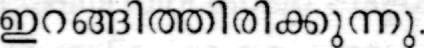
ഇറങ്ങിത്തിരിക്കുന്നു.
